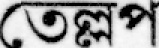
তেল্লপ
